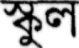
স্কুল
